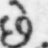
છે.
